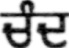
ਚੰਦ
